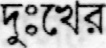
দুঃখের
